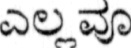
ಎಲ್ಲವೂ
